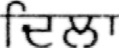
ਦਿਲਾ
